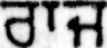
ਰਾਜ
